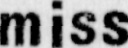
miss
